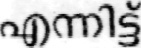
എന്നിട്ട്
